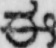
ಈ
